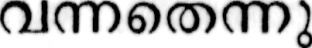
വന്നതെന്നു
